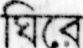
ঘিরে
